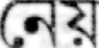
নেয়
